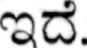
ಇದೆ.
